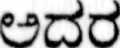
ಅದರ
